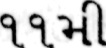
૧૧મી
